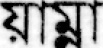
য়াম্না
